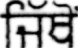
ਜਿੱਥੋਂ
